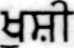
ਖੁਸ਼ੀ
